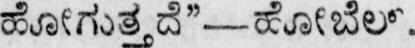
ಹೋಗುತ್ತದೆ”-ಹೋಬೆಲ್.
